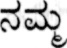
ನಮ್ಮ
